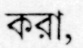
করা,
